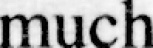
much
